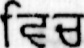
ਵਿਚ
